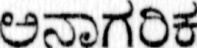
ಅನಾಗರಿಕ
